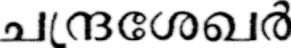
ചന്ദ്രശേഖര്‍
